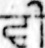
ਵੀ
